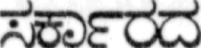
ಸರ್ಕಾರದ
